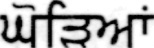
ਘੋੜਿਆਂ
